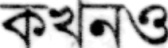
কখনও
